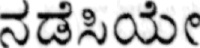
ನಡೆಸಿಯೇ
